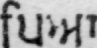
ਪਿਆ
